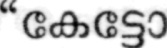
“കേട്ടോ
